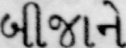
બીજાને
